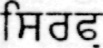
ਸਿਰਫ਼
